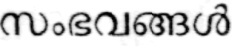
സംഭവങ്ങള്‍
